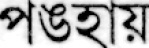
পঙহায়
